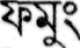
ফমুং
